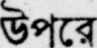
উপরে
